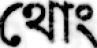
থোং
